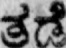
ತಡೆ
